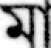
মা
